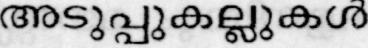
അടുപ്പുകല്ലുകള്‍
